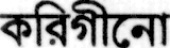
করিগীনো
